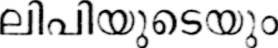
ലിപിയുടെയും
